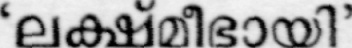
ലക്ഷ്‌മീഭായി'
